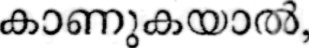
കാണുകയാല്‍,
